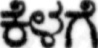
ಕೆಳಗೆ
